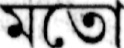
মতো
